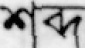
শব্দ
